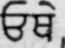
ਓਥੇ,
